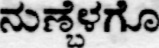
ನುಣ್ಬೆಳಗೊ
